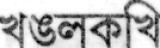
খঙলকখি
